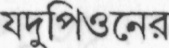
যদুপিওনের
